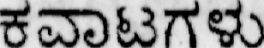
ಕವಾಟಗಳು
